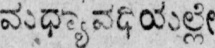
ಮಧ್ಯಾವಧಿಯಲ್ಲೇ
